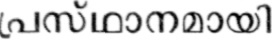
പ്രസ്ഥാനമായി
